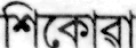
শিকোৱা
